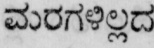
ಮರಗಳಿಲ್ಲದ
